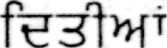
ਦਿਤੀਆਂ
